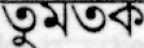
তুমতক
